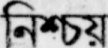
নিশ্চয়
